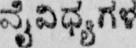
ವೈವಿಧ್ಯಗಳ
